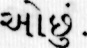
ઓછું.
